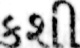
કશી
